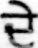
ਦੇ
